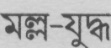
মল্ল-যুদ্ধ
